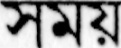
সময়
